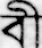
বী
